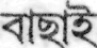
বাছাই
